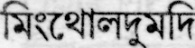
মিংথোলদুমদি
